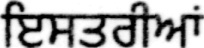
ਇਸਤਰੀਆਂ
